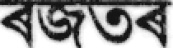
ৰজতৰ
